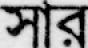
সার
